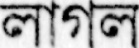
লাগল
